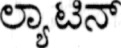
ಲ್ಯಾಟಿನ್
